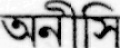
অনীসি
